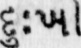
દુઃખી
